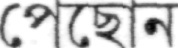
পেছোন
